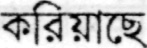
করিয়াছে
